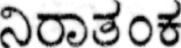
ನಿರಾತಂಕ
